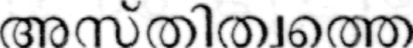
അസ്തിത്വത്തെ
